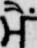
ਮੈਂ
